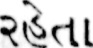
રહેતા
